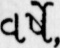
વર્ષે,
